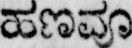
ಹಣವೂ
